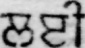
ਲਈ
